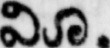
ಮೀ.
